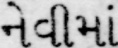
નેવીમાં
